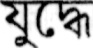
যুদ্ধে
